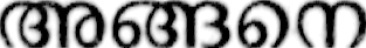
അങ്ങനെ
